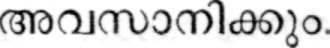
അവസാനിക്കും.
